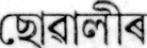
ছোৱালীৰ
